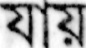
যায়
